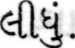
લીધું.
